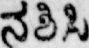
ನಶಿಸಿ
